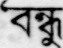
‘বন্ধু
